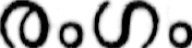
രംഗം
